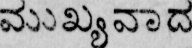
ಮುಖ್ಯವಾದ
